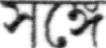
সঙ্গে
